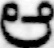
ಆ
